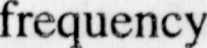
frequency
